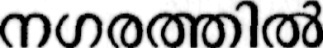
നഗരത്തില്‍
